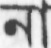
না
